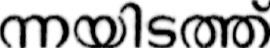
ന്നയിടത്ത്
